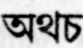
অথচ
